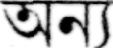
অন্য
